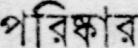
পরিষ্কার
